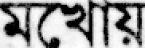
মখোয়
